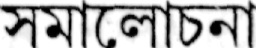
সমালোচনা
